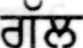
ਗੱਲ
